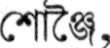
শোঞ্জৈ,
